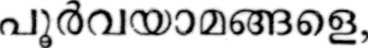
പൂര്‍വയാമങ്ങളെ,
